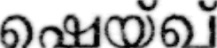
ഷെയ്ഖ്
